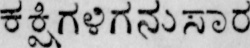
ಕಕ್ಷಿಗಳಿಗನುಸಾರ
